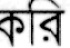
করি
